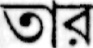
তার
